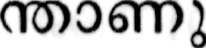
ന്താണു
